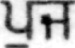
ਪੁਜ
